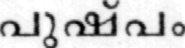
പുഷ്പം
